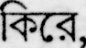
কিরে,
